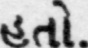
હતો.
